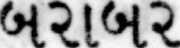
બરાબર
